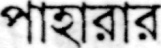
পাহারার
